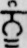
ਨੂੰ
